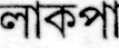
লাকপা
